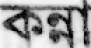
কন্না
